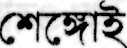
শেঙ্গোই
